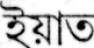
ইয়াত
